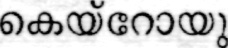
കെയ്റോയു
